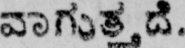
ವಾಗುತ್ತದೆ.
